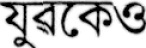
যুৱকেও
